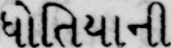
ધોતિયાની
